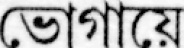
ভোগায়ে
